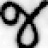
જ
